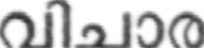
വിചാര
